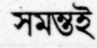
সমন্তই
